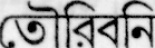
তৌরিবনি
